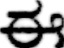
ಈ
